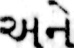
અને
